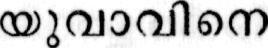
യുവാവിനെ
